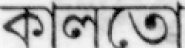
কালতো
